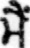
ਮੈਂ
